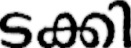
ടക്കി
